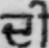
ਦੀ
